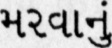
મરવાનું
